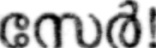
സേര്‍!
